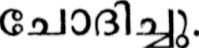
ചോദിച്ചു.
